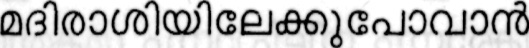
മദിരാശിയിലേക്കുപോവാന്‍
